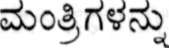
ಮಂತ್ರಿಗಳನ್ನು
